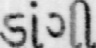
ડાંગી
